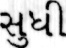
સુધી
